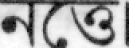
নত্তে।
